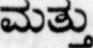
ಮತ್ತು
